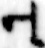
ન
